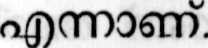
എന്നാണ്.
